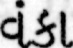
વંકા
